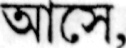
আসে,
